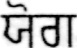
ਯੋਗ
